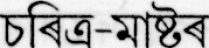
চৰিত্র-মাষ্টৰ
